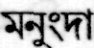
মনুংদা
